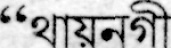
“থায়নগী
